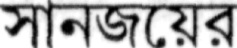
সানজয়ের
